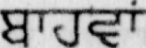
ਬਾਹਵਾਂ
